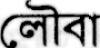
লৌবা
